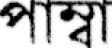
পাম্বা
